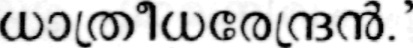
ധാത്രീധരേന്ദ്രന്‍.'
